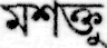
মশক্তু
